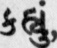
કહ્યું,
